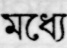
মধ্যে
